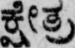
ಕ್ಷೇತ್ರ
